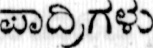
ಪಾದ್ರಿಗಳು
